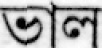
ভাল
